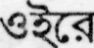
ওইরে
